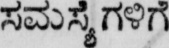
ಸಮಸ್ಯೆಗಳಿಗೆ
